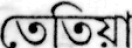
তেতিয়া
